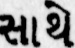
સાથે
